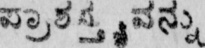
ಪ್ರಾಶಸ್ತ್ಯವನ್ನು
